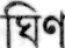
ঘিণ
